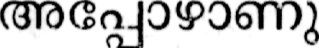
അപ്പോഴാണു
